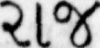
રાજ
